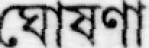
ঘোষণা
